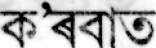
ক'ৰবাত
